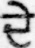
ਦੇ
